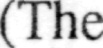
(The
